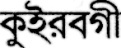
কুইরবগী
